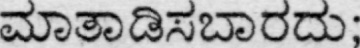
ಮಾತಾಡಿಸಬಾರದು;
